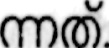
ന്നത്.
